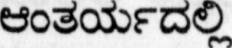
ಆಂತರ್ಯದಲ್ಲಿ
